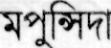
মপুন্সিদা
